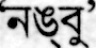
‘নঙবু’
